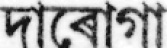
দাৰোগা
